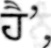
ਹੈ',
